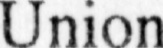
Union
